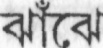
ঝাঁঝে
